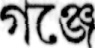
গঞ্জে
